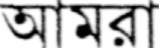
আমরা
